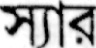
স্যার
